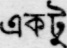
একটু
